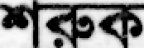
শরুক
